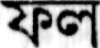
ফল
